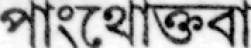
পাংথোক্তবা
